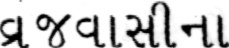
વ્રજવાસીના
